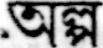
অল্প
